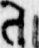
તો
